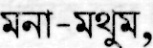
মনা-মথুম,
